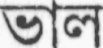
ভাল
